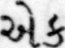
એક
